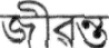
জীৱন্ত
